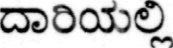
ದಾರಿಯಲ್ಲಿ
